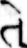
તે
